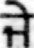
ਜੇ
